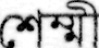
শেম্মী
